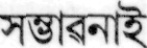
সম্ভাৱনাই
